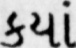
કયાં
